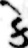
કે
